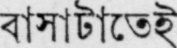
বাসাটাতেই
